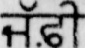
ਜੱਫ਼ੀ
